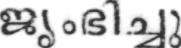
ജൃംഭിച്ചു
